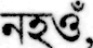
নহওঁ,
